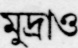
মুদ্রাও
